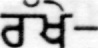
ਰੱਖੇ-
